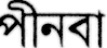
পীনবা
